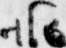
નહિ
